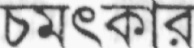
চমৎকার
